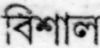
বিশাল
